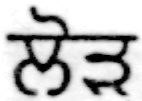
ਲੋੜ
